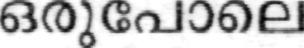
ഒരുപോലെ
